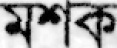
মশক
